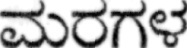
ಮರಗಳ
